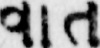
વાત
